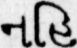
નહિ
